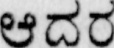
ಆದರ
